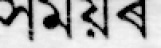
সময়ৰ
